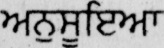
ਅਨੁਸੂਇਆ
